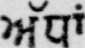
ਅੱਧਾਂ
